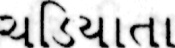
ચડિયાતા
